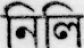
নিলি
